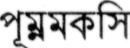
পূম্নমকসি
